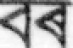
বৰ
